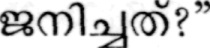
ജനിച്ചത്?"
